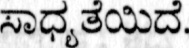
ಸಾಧ್ಯತೆಯಿದೆ.
